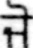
ਜੋ
